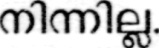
നിന്നില്ല.
